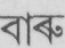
বাৰু
